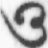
ও
